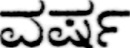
ವರ್ಷ
